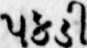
પકડી
